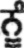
ਨੂੰ
